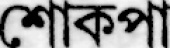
শোকপা
